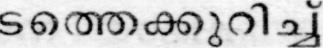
ടത്തെക്കുറിച്ച്
